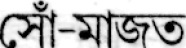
সোঁ-মাজত
